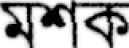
মশক
